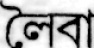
লৈবা
